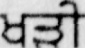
ਖੜੀ
